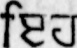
ਇਹ
